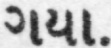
ગયા.
